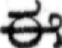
ಈ
